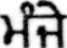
ਮੰਜੇ
